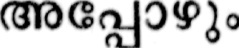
അപ്പോഴും
